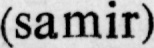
(samir)
